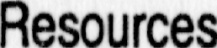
Resources
